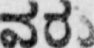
ವರು
